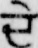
ਦੇ
